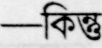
–কিন্তু
